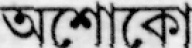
অশোকো
